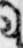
યે
